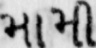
મામી
